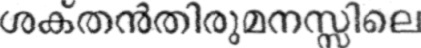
ശക്തന്‍തിരുമനസ്സിലെ
